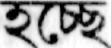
হচ্ছে
